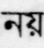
নয়
